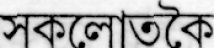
সকলোতকৈ
